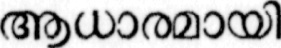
ആധാരമായി
